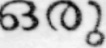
ഒരു
